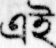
এই
